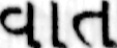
વાત
